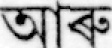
আৰু
